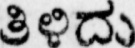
ತಿಳಿದು
